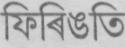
ফিৰিঙতি
